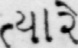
ત્યારે
